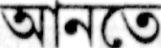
আনতে
